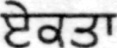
ਏਕਤਾ
